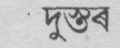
দুস্তৰ
